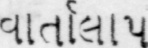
વાર્તાલાપ
